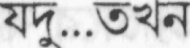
যদু...তখন
